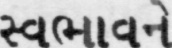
સ્વભાવને
